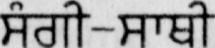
ਸੰਗੀ-ਸਾਥੀ
